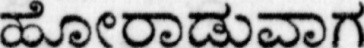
ಹೋರಾಡುವಾಗ
